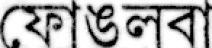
ফোঙলবা
